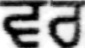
ਵਰ
